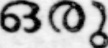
ഒരു
